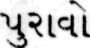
પુરાવો
